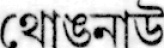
থোঙনাউ
